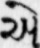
એ
